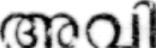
അവി
